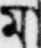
মা
